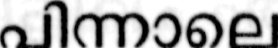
പിന്നാലെ
